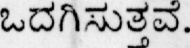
ಒದಗಿಸುತ್ತವೆ.
